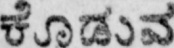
ಕೊಡುವ
